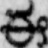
ಈ
